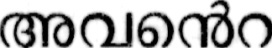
അവന്റെ
